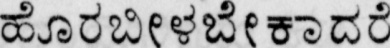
ಹೊರಬೀಳಬೇಕಾದರೆ
